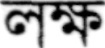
লক্ষ
